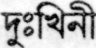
দুঃখিনী
